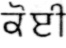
ਕੋਈ
